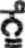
ਨੂੰ
